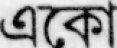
একো
